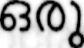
ഒരു
